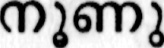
നൂണു
